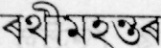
ৰথীমহন্তৰ
